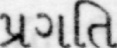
પ્રગતિ
